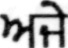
ਅਜੇ
